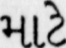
માટે
